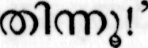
തിന്നൂ!'
